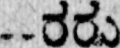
--ರರು
